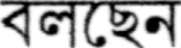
বলছেন
